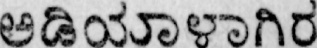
ಅಡಿಯಾಳಾಗಿರ
